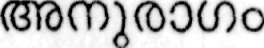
അനുരാഗം
